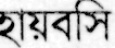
হায়বসি
